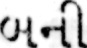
બની
